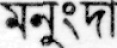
মনুংদা
